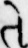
તે
